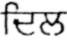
ਦਿਲ
